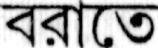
বরাতে
